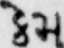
કેમ
